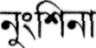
নুংশিনা
